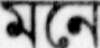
মনে
